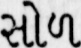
સોળ
